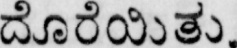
ದೊರೆಯಿತು.
